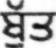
ਬੁੱਤ
